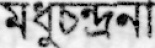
মধুচন্দ্রনা
